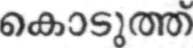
കൊടുത്ത്
